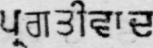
ਪ੍ਰਗਤੀਵਾਦ
